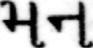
મન
